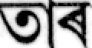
তাৰ
